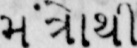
મંત્રોથી
